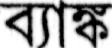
ব্যাঙ্ক
